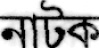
নাটক
